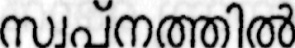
സ്വപ്നത്തില്‍
